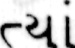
ત્યાં
